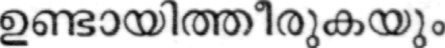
ഉണ്ടായിത്തീരുകയും
